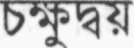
চক্ষুদ্বয়
